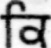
ਕਿ
